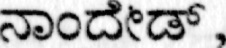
ನಾಂದೇಡ್,
